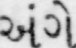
અંગે
